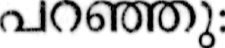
പറഞ്ഞു:
